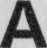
A
